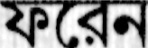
ফরেন
